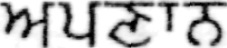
ਅਪਣਾਨ
